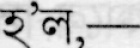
হ'ল,-
